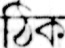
ঠিক
